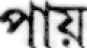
পায়
